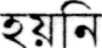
হয়নি
